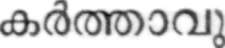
കര്‍ത്താവു
